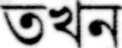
তখন
